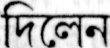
দিলেন
